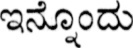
ಇನ್ನೊಂದು
